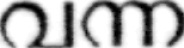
വന്ന
